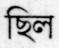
ছিল
